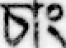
চাং
